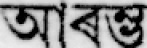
আৰম্ভ
